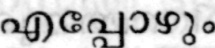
എപ്പോഴും
